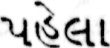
પહેલા
